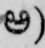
ಅ)
